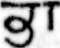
ਭਾ
